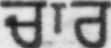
ਚਾਰ
